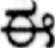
ಈ
